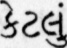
કેટલું
